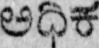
ಅಧಿಕ
